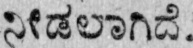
ನೀಡಲಾಗಿದೆ.
